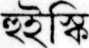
হুইস্কি
